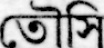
তৌসি
